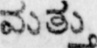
ಮತ್ತು
